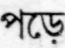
পড়ে
